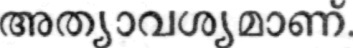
അത്യാവശ്യമാണ്.
